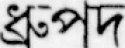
ধ্ৰুপদ
